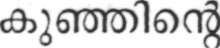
കുഞ്ഞിന്റെ
